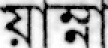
য়াম্না
